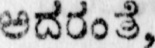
ಅದರಂತೆ,
